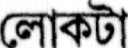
লোকটা
